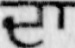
ਦਾ
